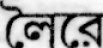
লৈরে
